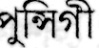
পুন্সিগী
